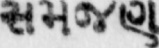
સમજણ
